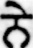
ਨੇ
